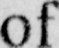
of
